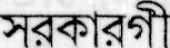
সরকারগী
